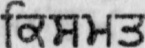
ਕਿਸਮਤ
